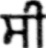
ਸੀ
